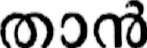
താന്‍
